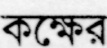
কক্ষের
